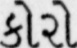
કોરો
